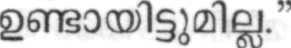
ഉണ്ടായിട്ടുമില്ല.”
